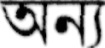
অন্য
